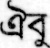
ঐবু
